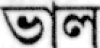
ভাল
